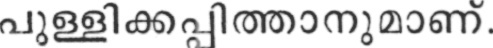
പുള്ളിക്കപ്പിത്താനുമാണ്.
